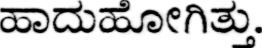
ಹಾದುಹೋಗಿತ್ತು.
